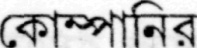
কোম্পানির
